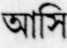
আসি
